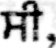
ਸੀ,
